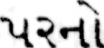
પરનો
